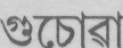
গুচোৱা
